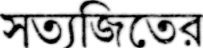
সত্যজিতের
